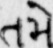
તમે
